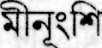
মীনূংশি
